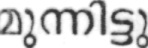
മുന്നിട്ടു
